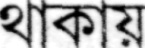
থাকায়
